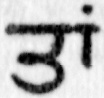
ਤਾਂ
